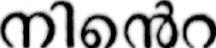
നിന്റെ
